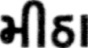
મીઠા
